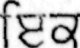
ਇਕ
